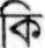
কি
